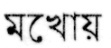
মখোয়
